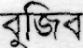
বুজিব
